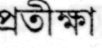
প্রতীক্ষা
